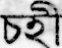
চহী
